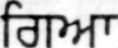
ਗਿਆ
